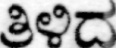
ತಿಳಿದ
